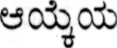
ಆಯ್ಕೆಯ
